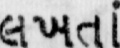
લખતાં
